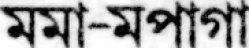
মমা-মপাগা
